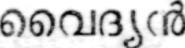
വൈദ്യന്‍
